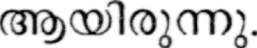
ആയിരുന്നു.
